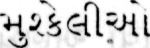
મુશ્કેલીઓ
